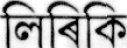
লিৰিকি
